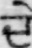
ਦੇ
